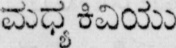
ಮಧ್ಯಕಿವಿಯು
